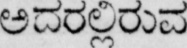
ಅದರಲ್ಲಿರುವ
